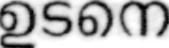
ഉടനെ
